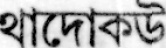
থাদোকউ
